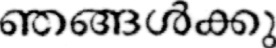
ഞങ്ങള്‍ക്കു
